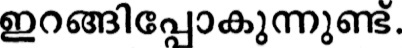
ഇറങ്ങിപ്പോകുന്നുണ്ട്.
